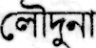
লৌদুনা
